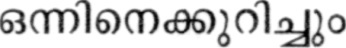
ഒന്നിനെക്കുറിച്ചും
